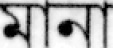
মানা
